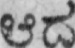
ಆದ
